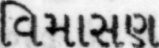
વિમાસણ
